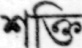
শক্তি
